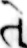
તે
